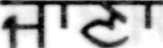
ਜਾਣਾ
